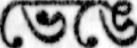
ভেঙে
